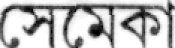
সেমেকা
